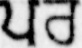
ਪਰ
